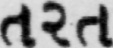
તરત
